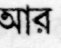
আর
